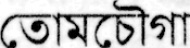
তোমচৌগা
